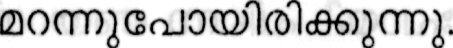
മറന്നുപോയിരിക്കുന്നു.
